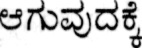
ಆಗುವುದಕ್ಕೆ
